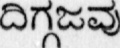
ದಿಗ್ಗಜವು
